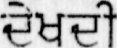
ਦੇਖਦੀ
